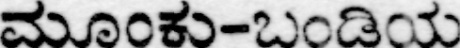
ಮೂಂಕು-ಬಂಡಿಯ
